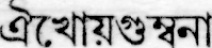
ঐখোয়গুম্বনা
